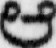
ಆ
